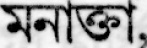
মনাক্তা,
